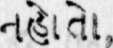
નહોતો,
